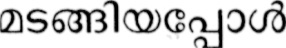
മടങ്ങിയപ്പോള്‍
